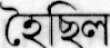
হৈছিল
